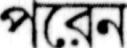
পরেন
